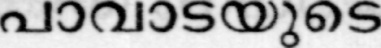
പാവാടയുടെ
